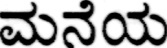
ಮನೆಯ
